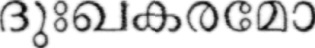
ദുഃഖകരമോ
